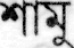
শামু
